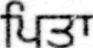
ਪਿਤਾ
